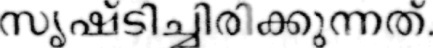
സൃഷ്ടിച്ചിരിക്കുന്നത്.
